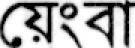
য়েংবা
